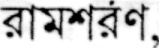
রামশরণ,
